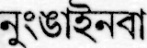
নুংঙাইনবা
